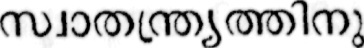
സ്വാതന്ത്ര്യത്തിനു
